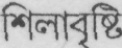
শিলাবৃষ্টি
